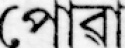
পোৱা
